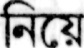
নিয়ে
